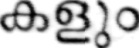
കളും
